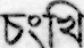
চংখি
